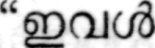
“ഇവള്‍
